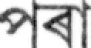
পৰা
